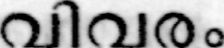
വിവരം
